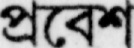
প্রবেশ
